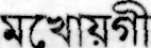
মখোয়গী
